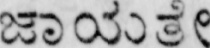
ಜಾಯತೇ
